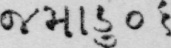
જમાડુ૦દ
